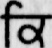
ਕਿ
